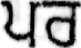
ਪਰ
